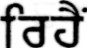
ਰਿਹੈਂ
